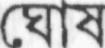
ঘোষ
